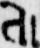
તો
